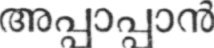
അപ്പാപ്പാന്‍
